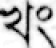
খং
